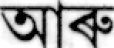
আৰু
